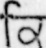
ਕਿ
